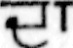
ਦਾ
